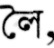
লৈ,
